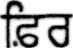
ਫ਼ਿਰ
